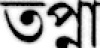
তপ্না
